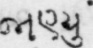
જાણ્યું
